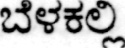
ಬೆಳಕಲ್ಲಿ
